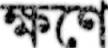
ক্ষণে
